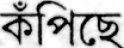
কঁপিছে
